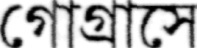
গোগ্রাসে
